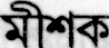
মীশক
